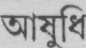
আষুধি
